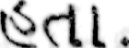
હતા.
